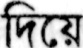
দিয়ে
